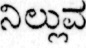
ನಿಲ್ಲುವ
